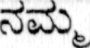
ನಮ್ಮ
